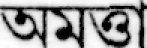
অমত্তা
